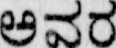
ಅವರ
